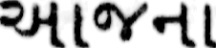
આજના
